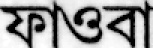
ফাওবা
